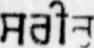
ਸਰੀਰ
